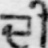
ਦੀ
